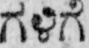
ಗಳಿಗೆ
